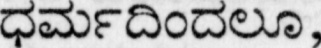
ಧರ್ಮದಿಂದಲೂ,
